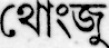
থোংজু
